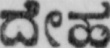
ದೇಹ
